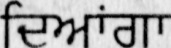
ਦਿਆਂਗਾ
